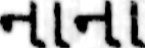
નાના
